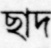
ছাদ
